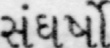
સંઘર્ષો
